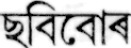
ছবিবোৰ
